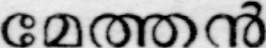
മേത്തന്‍
